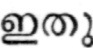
ഇതു
